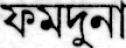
ফমদুনা
